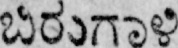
ಬಿರುಗಾಳಿ
